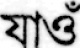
যাওঁ
